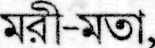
মরী-মতা,
